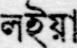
লইয়া
